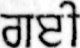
ਗਈ
